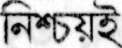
নিশ্চয়ই
